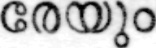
രേയും
